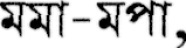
মমা-মপা,
